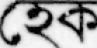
হেক
